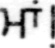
ਮਾਂ!
